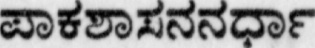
ಪಾಕಶಾಸನನರ್ಧಾ
